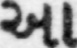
આ
